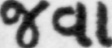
જવા
